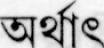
অর্থাৎ
